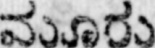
ಮೂರು
